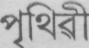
পৃথিৱী
